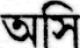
অসি
